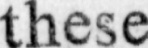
these
